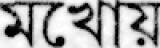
মখোয়
